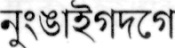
নুংঙাইগদগে
